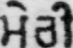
ਮੇਰੀ
